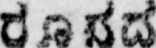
ರೂಪದ
